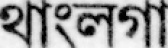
থাংলগা
